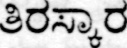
ತಿರಸ್ಕಾರ
